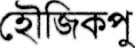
হৌজিকপু
